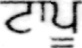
ਟਾਪੂ
